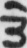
ਤੇ
